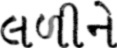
લળીને
